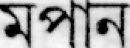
মপান
